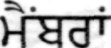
ਮੈਂਬਰਾਂ
